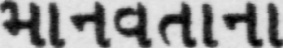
માનવતાના
